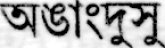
অঙাংদুসু
